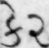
કેર
